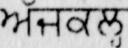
ਅੱਜਕਲ੍ਹ
